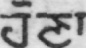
ਹੋਣਾ
